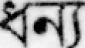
ধন্য
